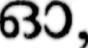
ഓ,
